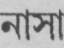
নাসা
